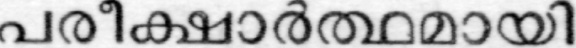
പരീക്ഷാര്‍ത്ഥമായി
